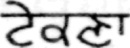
ਟੇਕਣਾ
